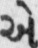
એ
